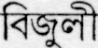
বিজুলী
